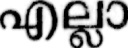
എല്ലാ
